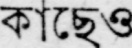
কাছেও
